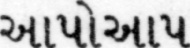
આપોઆપ
